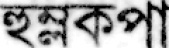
হুম্লকপা
